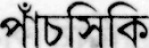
পাঁচসিকি
